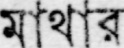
মাথার
